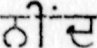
ਨੀਂਦ
